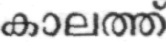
കാലത്ത്
